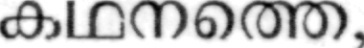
കഥനത്തെ,
